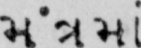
મંત્રમાં
